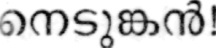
നെടുങ്കന്‍!
